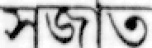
সজাত
